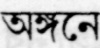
অঙ্গনে
